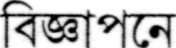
বিজ্ঞাপনে
